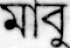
মাবু
